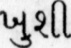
ખુશી
